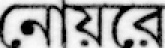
নোয়রে
